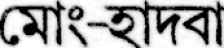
মোং-হাদবা
